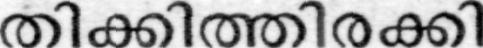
തിക്കിത്തിരക്കി
